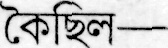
কৈছিল-
